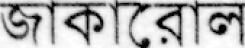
জাকারোল
